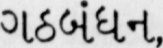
ગઠબંધન,
